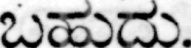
ಬಹುದು.
